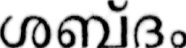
ശബ്ദം
